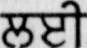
ਲਈ
